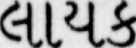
લાયક
